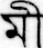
মী
